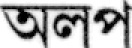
অলপ
